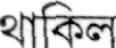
থাকিল
